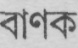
বাণক
